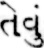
તેવું
